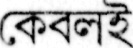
কেবলই
